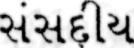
સંસદીય
